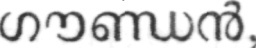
ഗൗണ്ഡന്‍,
